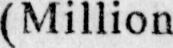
(Million
